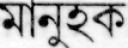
মানুহক
